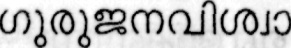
ഗുരുജനവിശ്വാ
